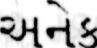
અનેક
